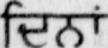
ਦਿਨਾਂ
